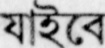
যাইবে
